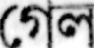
গেল
